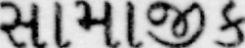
સામાજીક
